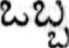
ಒಬ್ಬ
